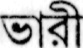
ভারী
